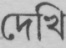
দেখি
